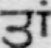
ਤਾਂ
